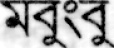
মবুংবু
